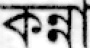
কন্না
